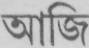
আজি
